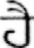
ਹੈ
